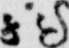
કંઈ
